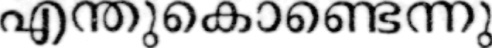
എന്തുകൊണ്ടെന്നു
